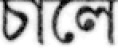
চালে
